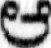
ಆ
